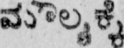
ಮೌಲ್ಯಕ್ಕೆ
